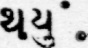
થયું.
